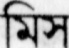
মিস
